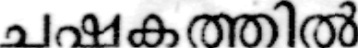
ചഷകത്തില്‍
